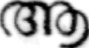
ആ
